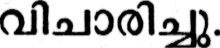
വിചാരിച്ചു.
